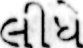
લીધે
